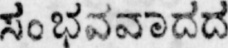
ಸಂಭವವಾದದ
